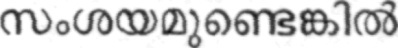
സംശയമുണ്ടെങ്കില്‍
